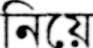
নিয়ে
